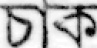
চাক
